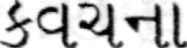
કવચના
